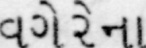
વગેરેના
